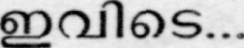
ഇവിടെ...
